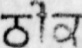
ਠੀਕ
